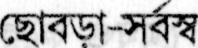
ছোবড়া-সর্বস্ব
